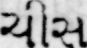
ચીસ
